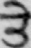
ਤੇ
